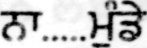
ਨਾ.....ਮੁੰਡੇ
